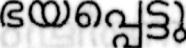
ഭയപ്പെട്ടു
